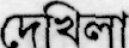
দেখিলা
